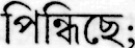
পিন্ধিছে;
